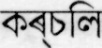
কৰ্‌চলি
